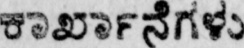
ಕಾರ್ಖಾನೆಗಳು
